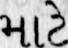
માટે
